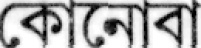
কোনোবা
